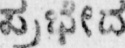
ಪ್ರಭೇದ
